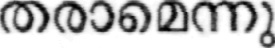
തരാമെന്നു
